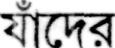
যাঁদের
